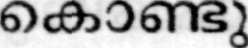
കൊണ്ടു
